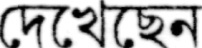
দেখেছেন
